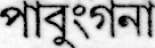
পাবূংগনা
